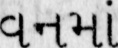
વનમાં
